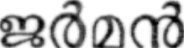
ജര്‍മന്‍
